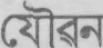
যৌৱন
